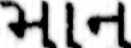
માન
